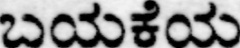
ಬಯಕೆಯ
